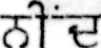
ਨੀਂਦ
